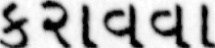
કરાવવા
